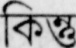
কিন্তু
